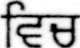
ਵਿਚ
